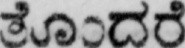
ತೊಂದರೆ
